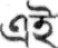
এই
